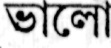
ভালো
